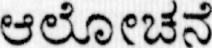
ಆಲೋಚನೆ
